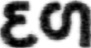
દળ
